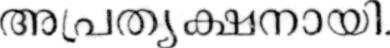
അപ്രത്യക്ഷനായി.
